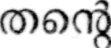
തന്റെ
